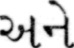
અને
